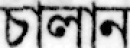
চালান
